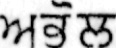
ਅਭੋਲ
